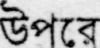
উপরে
